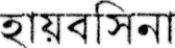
হায়বসিনা
